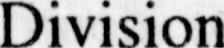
Division
